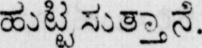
ಹುಟ್ಟಿಸುತ್ತಾನೆ.
